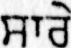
ਸਾਰੇ
